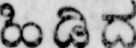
ಹಿಡಿದ
